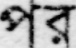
পর
